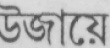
উজায়ে
